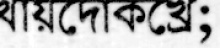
খায়দোকখ্রে;
